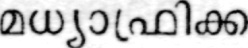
മധ്യാഫ്രിക്ക
